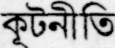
কূটনীতি
